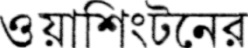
ওয়াশিংটনের
